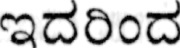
ಇದರಿಂದ
